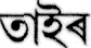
তাইৰ
